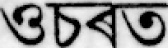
ওচৰত
